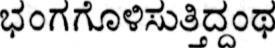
ಭಂಗಗೊಳಿಸುತ್ತಿದ್ದಂಥ
